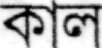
কাল
